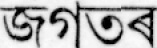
জগতৰ
